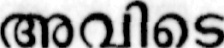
അവിടെ
